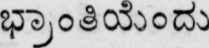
ಭ್ರಾಂತಿಯೆಂದು
